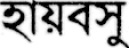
হায়বসু
